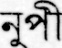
নুপী
